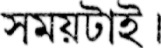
সময়টাই।
